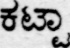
ಕಟ್ಟಾ
